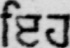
ਇਹ
